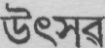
উৎসৱ
